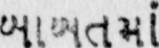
બાબતમાં
